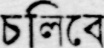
চলিবে
